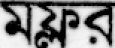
মফ্লর
